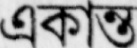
একান্ত
